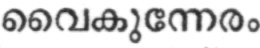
വൈകുന്നേരം
